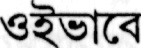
ওইভাবে
